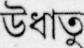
উধাতু
